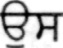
ਉਸ
